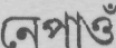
নেপাওঁ
